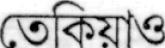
তেকিয়াও
